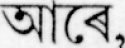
আৰে,
